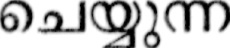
ചെയ്യുന്ന
